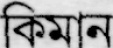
কিমান
